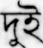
দুই
